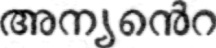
അന്യന്റെ
